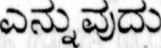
ಎನ್ನುವುದು
